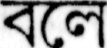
বলে
